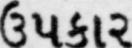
ઉપકાર
